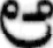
ಆ
